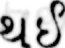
થઈ
